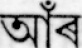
আঁৰ
